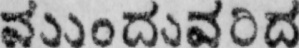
ಮುಂದುವರಿದ
